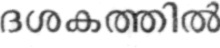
ദശകത്തില്‍
